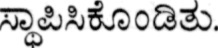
ಸ್ಥಾಪಿಸಿಕೊಂಡಿತು.
